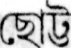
ছোট্ট
